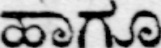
ಹಾಗೂ
